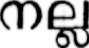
നല്ല
